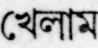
খেলাম
